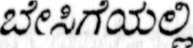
ಬೇಸಿಗೆಯಲ್ಲಿ
